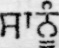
ਸਾਨੂੰ
